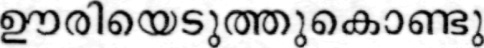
ഊരിയെടുത്തുകൊണ്ടു
